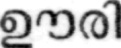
ഊരി
